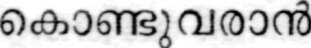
കൊണ്ടുവരാന്‍
